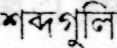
শব্দগুলি
